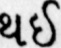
થઈ
